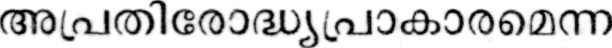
അപ്രതിരോദ്ധ്യപ്രാകാരമെന്ന
